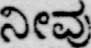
ನೀವು
